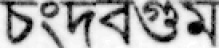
চংদবগুম
